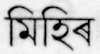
মিহিৰ
